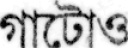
গাটোও
